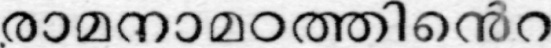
രാമനാമഠത്തിന്റെ
